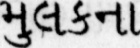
મુલકના
